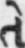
તે
